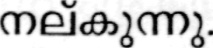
നല്കുന്നു.
